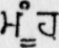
ਮੂੰਹ
